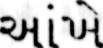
આંખે
